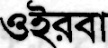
ওইরবা
